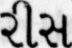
રીસ
